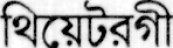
থিয়েটরগী
